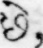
છે,
